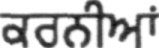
ਕਰਨੀਆਂ
